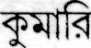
কুমারি
